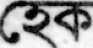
হেক
